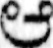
ಆ
